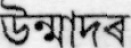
উন্মাদৰ
